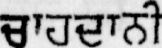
ਚਾਹਦਾਨੀ
